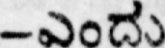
-ಎಂದು
